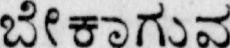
ಬೇಕಾಗುವ
